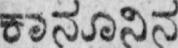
ಕಾನೂನಿನ
